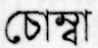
চোম্বা
